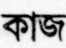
কাজ
